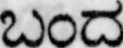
ಬಂದ
